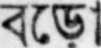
বড়ো
